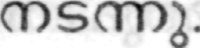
നടന്നു.
